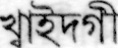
খ্বাইদগী
